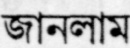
জানলাম
